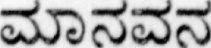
ಮಾನವನ
